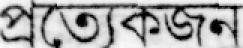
প্ৰত্যেকজন
